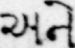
અને
